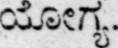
ಯೋಗ್ಯ.
